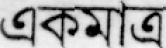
একমাত্র
